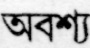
অবশ্য
